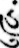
હું
